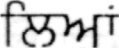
ਲਿਆਂ
